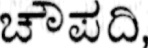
ಚೌಪದಿ,
